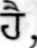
ਹੈ,
